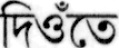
দিওঁতে
